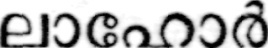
ലാഹോര്‍
